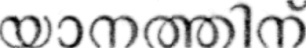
യാനത്തിന്
